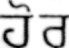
ਹੋਰ
